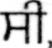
ਸੀ,
